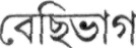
বেছিভাগ
